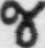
જ
